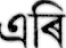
এৰি
